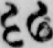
દઢ
